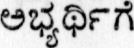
ಅಭ್ಯರ್ಥಿಗೆ
